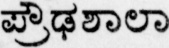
ಪ್ರೌಢಶಾಲಾ
